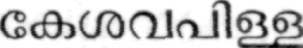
കേശവപിള്ള
